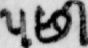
પછી
